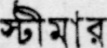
স্টীমার
